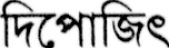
দিপোজিৎ
